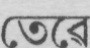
তেৱে
